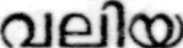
വലിയ
